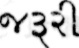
જરૂરી
